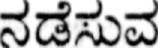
ನಡೆಸುವ
